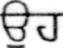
ਉਹ
